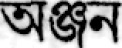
অঞ্জন
